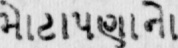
મોટાપણાનો
